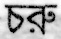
চরু
